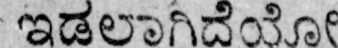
ಇಡಲಾಗಿದೆಯೋ
